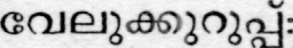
വേലുക്കുറുപ്പ്:
